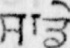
ਸਾਡੇ
